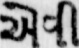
એવી
